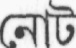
নোট
